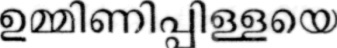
ഉമ്മിണിപ്പിള്ളയെ
